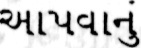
આપવાનું
